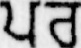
ਪਰ
